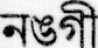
নঙগী
